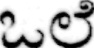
ಒಲೆ
